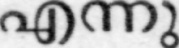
എന്നു
